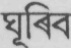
ঘূৰিব
